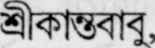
শ্রীকান্তবাবু,
